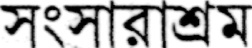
সংসারাশ্রম
